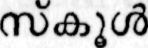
സ്കൂള്‍
